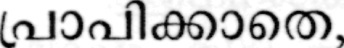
പ്രാപിക്കാതെ,
